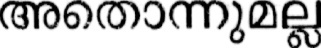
അതൊന്നുമല്ല
